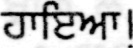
ਹਾਇਆ!
